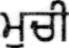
ਮੁਚੀ
